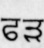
ਫੜ
